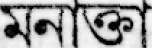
মনাক্তা
